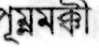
পূম্নমক্কী
